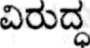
ವಿರುದ್ಧ
